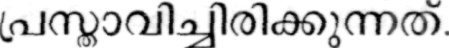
പ്രസ്താവിച്ചിരിക്കുന്നത്.
